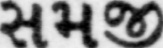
સમજી
